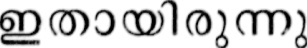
ഇതായിരുന്നു
